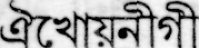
ঐখোয়নীগী
